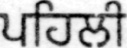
ਪਹਿਲੀ
